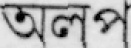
অলপ
